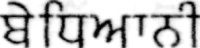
ਬੇਧਿਆਨੀ
